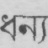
ধন্য
